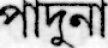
পাদুনা
